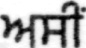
ਅਸੀਂ
